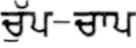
ਚੁੱਪ-ਚਾਪ
